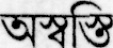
অস্বস্তি
